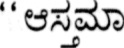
"ಆಸ್ತಮಾ
